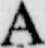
A
